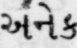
અનેક
